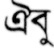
ঐবু
